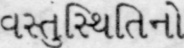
વસ્તુસ્થિતિનો
